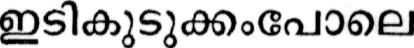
ഇടികുടുക്കംപോലെ
